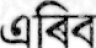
এৰিব
